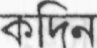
কদিন
